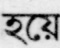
হয়ে
